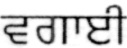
ਵਗਾਈ
